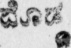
ದೊಡ್ಡ
